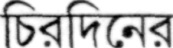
চিরদিনের
